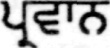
ਪ੍ਰਵਾਨ
